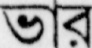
ভার
